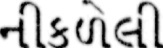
નીકળેલી
